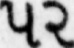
પર
